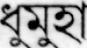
ধুমুহা
